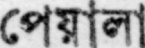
পেয়ালা
